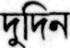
দুদিন
